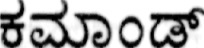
ಕಮಾಂಡ್
